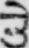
ਤੇ
